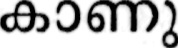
കാണു
